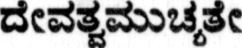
ದೇವತ್ವಮುಚ್ಯತೇ
